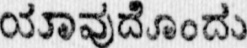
ಯಾವುದೊಂದು
